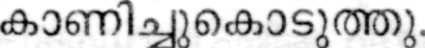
കാണിച്ചുകൊടുത്തു.
